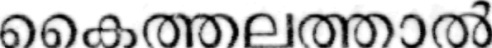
കൈത്തലത്താല്‍
